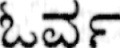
ಓರ್ವ
